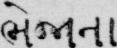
ભેજાના
